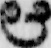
ಆ
